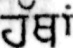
ਹੱਥਾਂ
